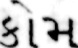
કોમ
